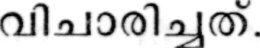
വിചാരിച്ചത്.
